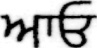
ਆਓ
